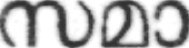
സമാ
